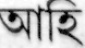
আহি
